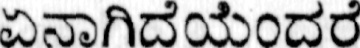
ಏನಾಗಿದೆಯೆಂದರೆ
